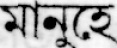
মানুহে
